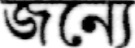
জন্যে
